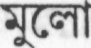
মুলো
